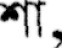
শা,
